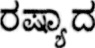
ರಷ್ಯಾದ
